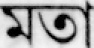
মতা
